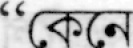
"কেনে
